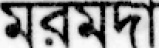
মরমদা
